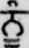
ਨੂੰ
